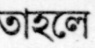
তাহলে
